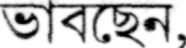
ভাবছেন,
